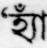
‘হ্যাঁ
